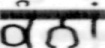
ਕੰਨਾਂ
